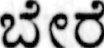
ಬೇರೆ
